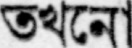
তখনো
